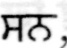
ਸਨ,
